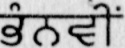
ਭੰਨਵੀਂ
